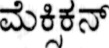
ಮೆಕ್ಸಿಕನ್
